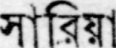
সারিয়া
